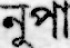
নুপা
